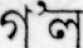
গ'ল
